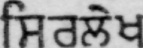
ਸਿਰਲੇਖ
